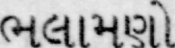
ભલામણો
